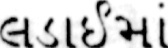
લડાઈમાં
